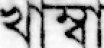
খাম্বা
